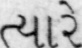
ત્યારે
